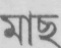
মাছ
